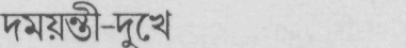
দময়ন্তী-দুখে
